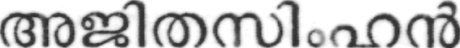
അജിതസിംഹന്‍
